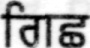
ਗਿਛ
